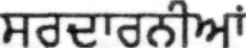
ਸਰਦਾਰਨੀਆਂ
